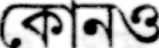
কোনও
